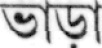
ভাড়া
